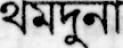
থমদুনা
